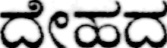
ದೇಹದ
